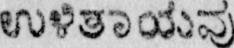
ಉಳಿತಾಯವು
